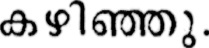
കഴിഞ്ഞു.
